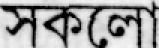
সকলো
